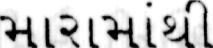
મારામાંથી
